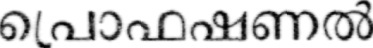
പ്രൊഫഷണല്‍
